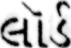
લૉર્ડ
